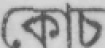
কোচ
